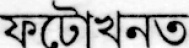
ফটোখনত
